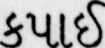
કપાઈ
